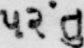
પરંતુ
